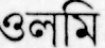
ওলমি
